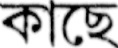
কাছে
